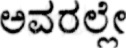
ಅವರಲ್ಲೇ
